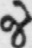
જે
